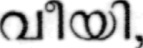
വീയി,
